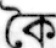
কৈ
